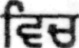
ਵਿਚ
